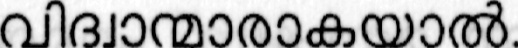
വിദ്വാന്മാരാകയാല്‍.
